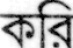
করি
